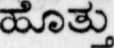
ಹೊತ್ತು
